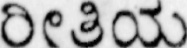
ರೀತಿಯ
